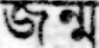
জন্ম
